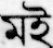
মই
